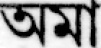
অমা
